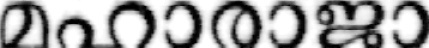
മഹാരാജാ
